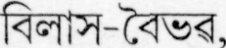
বিলাস-বৈভৱ,
